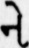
ને
